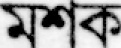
মশক
